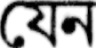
যেন
